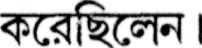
করেছিলেন।
